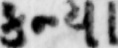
કન્યા
